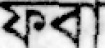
ফবা
